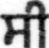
ਸੀ
